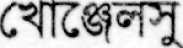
খোঞ্জেলসু
